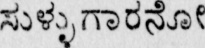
ಸುಳ್ಳುಗಾರನೋ
